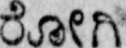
ರೋಗಿ
